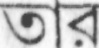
তার
